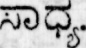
ಸಾಧ್ಯ.
